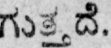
ಗುತ್ತದೆ.
